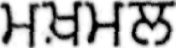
ਮਖ਼ਮਲ
